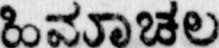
ಹಿಮಾಚಲ
